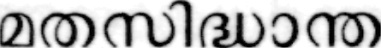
മതസിദ്ധാന്ത
